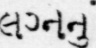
લગ્નનનું
